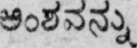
ಅಂಶವನ್ನು
